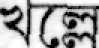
খল্লে
